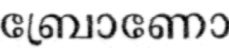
ബ്രോണോ
